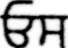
ਓਸ
